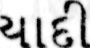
યાદી
